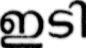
ഇടി
